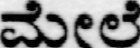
ಮೇಲೆ
